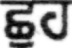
ਛੁਹ
